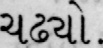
ચઢ્યો.
